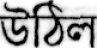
উঠিল
